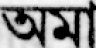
অমা
